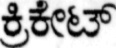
ಕ್ರಿಕೇಟ್
